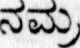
ನಮ್ರ
